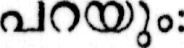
പറയും:
